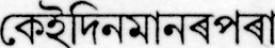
কেইদিনমানৰপৰা
